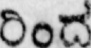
ರಿಂದ
